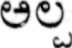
ಅಲ್ಪ
